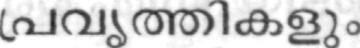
പ്രവൃത്തികളും
